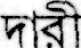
দারী
